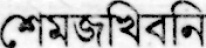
শেমজখিবনি
